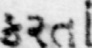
કરતાં
